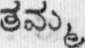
ತಮ್ಮ
